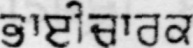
ਭਾਈਚਾਰਕ
